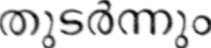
തുടര്‍ന്നും
